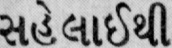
સહેલાઈથી
